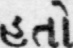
હતો
